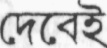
দেবেই
